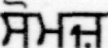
ਸੋਮਜ਼
